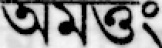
অমত্তং
